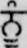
ਨੂੰ
